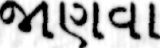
જાણવા
